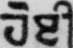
ਹੋਈ
